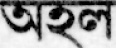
অহল
